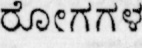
ರೋಗಗಳ
